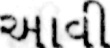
આવી
